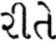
રીતે
